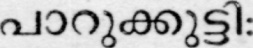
പാറുക്കുട്ടി:
